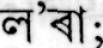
ল'ৰা;
